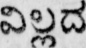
ವಿಲ್ಲದ
